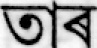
তাৰ
